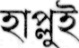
হাপ্লুই
